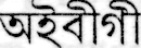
অইবীগী
